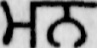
ਮਨ
